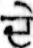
ਦੇ
